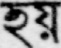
হয়
